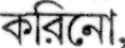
“করিনো,
